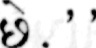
છે."
